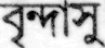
বৃন্দাসু
